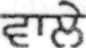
ਵਾਲੇ
